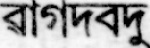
ৱাগদবদু
